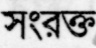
সংরক্ত
